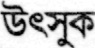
উত্সুক
